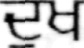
ਦੁਖ
